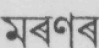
মৰণৰ
